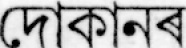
দোকানৰ
